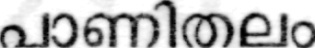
പാണിതലം
